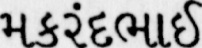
મકરંદભાઈ
